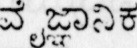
ವೈಜ್ಞಾನಿಕ
